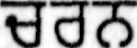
ਚਰਨ
